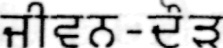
ਜੀਵਨ-ਦੌੜ
